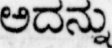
ಅದನ್ನು
